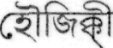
হৌজিক্কী
